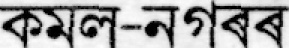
কমল-নগৰৰ
